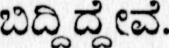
ಬಿದ್ದಿದ್ದೇವೆ.
